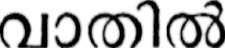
വാതില്‍
